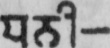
ਧਨੀ-
